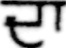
ਦਾ
